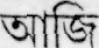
আজি
